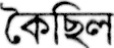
কৈছিল
